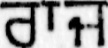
ਰਾਜ
